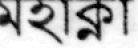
মহাক্না
